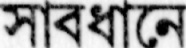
সাবধানে
